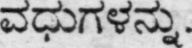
ವಧುಗಳನ್ನು.
